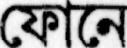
ফোনে
